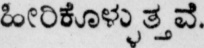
ಹೀರಿಕೊಳ್ಳುತ್ತವೆ.
